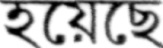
হয়েছে
